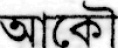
আকৌ
